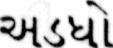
અડધો
